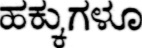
ಹಕ್ಕುಗಳೂ
